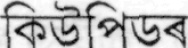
কিউপিডৰ
